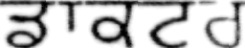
ਡਾਕਟਰ
